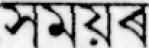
সময়ৰ
